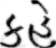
કહે
